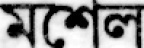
মশেল
